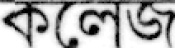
কলেজ
